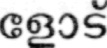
ളോട്
